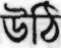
উঠি
